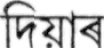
দিয়াৰ
